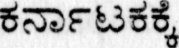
ಕರ್ನಾಟಕಕ್ಕೆ
